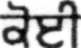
ਕੋਈ
